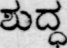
ಶುದ್ಧ
